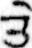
ਤੇ
